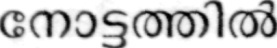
നോട്ടത്തില്‍
